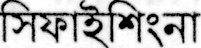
সিফাইশিংনা
